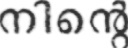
നിന്റെ
